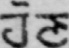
ਹੋਣ
